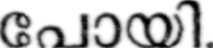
പോയി.
